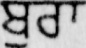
ਬੁਰਾ
